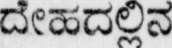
ದೇಹದಲ್ಲಿನ
